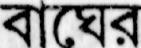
বাঘের
